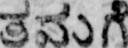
ತಮಗೆ
